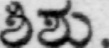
ಶಿಶು.
